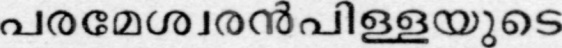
പരമേശ്വരന്‍പിള്ളയുടെ
